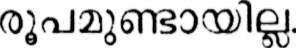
രൂപമുണ്ടായില്ല.
